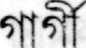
গার্গী
